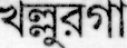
খল্লুরগা
